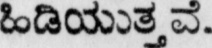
ಹಿಡಿಯುತ್ತವೆ.
